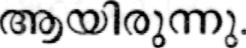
ആയിരുന്നു.
